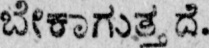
ಬೇಕಾಗುತ್ತದೆ.
